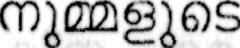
നുമ്മളുടെ
